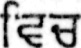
ਵਿਚ
